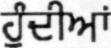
ਹੁੰਦੀਆਂ
